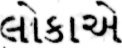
લોકાએ
